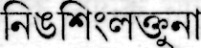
নিঙশিংলক্তুনা
